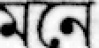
মনে
